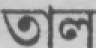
তাল
